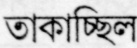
তাকাচ্ছিল
